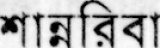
শান্নরিবা
